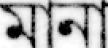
মানা
